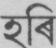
হৰি
